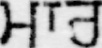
ਮਾਰ
